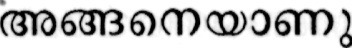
അങ്ങനെയാണു
